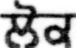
ਲੋਕ
